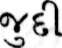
જુદી
